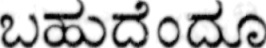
ಬಹುದೆಂದೂ
